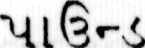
પાઉન્ડ
